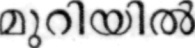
മുറിയില്‍
